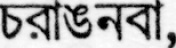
চরাঙনবা,
